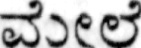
ಮೇಲೆ
